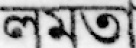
লমতা
